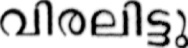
വിരലിട്ടു
